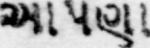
આપણા
